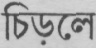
চিড়লে
